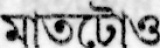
মাতটোও
